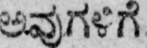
ಅವುಗಳಿಗೆ
